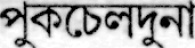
পুকচেলদুনা
